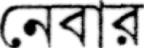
নেবার
